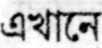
এখানে
